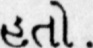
હતો.
